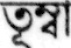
তূম্বা
